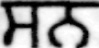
ਸਨ
